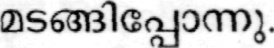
മടങ്ങിപ്പോന്നു.
